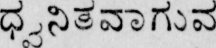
ಧ್ವನಿತವಾಗುವ
